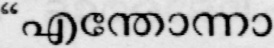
"എന്തോന്നാ
